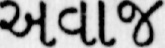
અવાજ
